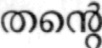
തന്റെ
